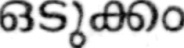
ഒടുക്കം
